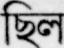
ছিল
